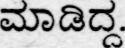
ಮಾಡಿದ್ದ.
